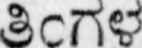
ತಿಂಗಳ
